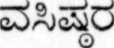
ವಸಿಷ್ಠರ
